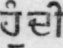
ਹੁੰਦੀ
